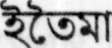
ইতৈমা
